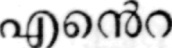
എന്റെ
